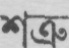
শত্ৰু
